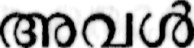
അവള്‍
